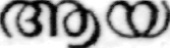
ആയ
